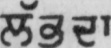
ਲੱਭਦਾ
